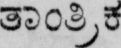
ತಾಂತ್ರಿಕ
